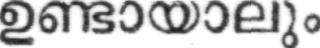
ഉണ്ടായാലും
